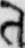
તે
